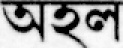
অহল
